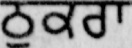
ਠੁਕਰਾ
